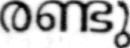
രണ്ടു
